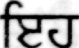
ਇਹ
